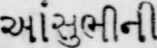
આંસુભીની
